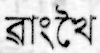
ৱাংখৈ
